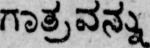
ಗಾತ್ರವನ್ನು
